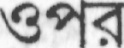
ওপর
